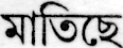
মাতিছে
